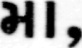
મા,
